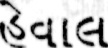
હેવાલ
